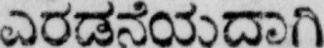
ಎರಡನೆಯದಾಗಿ
